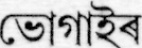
ভোগাইৰ
